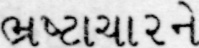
ભ્રષ્ટાચારને
